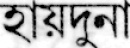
হায়দুনা
